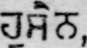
ਹੁਸੈਨ,
